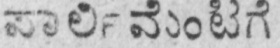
ಪಾರ್ಲಿಮೆಂಟಿಗೆ
